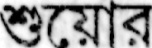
শুয়োর
